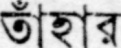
তাঁহার
